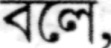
বলে,
